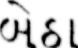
બેઠા
